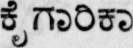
ಕೈಗಾರಿಕಾ
